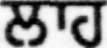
ਲਾਹ
